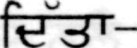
ਦਿੱਤਾ-
